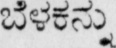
ಬೆಳಕನ್ನು
